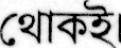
থোকই।
